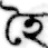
হৈ
